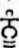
ਨੂੰ
